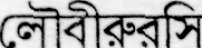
লৌবীরুরসি
